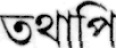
তথাপি
